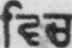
ਵਿਚ
